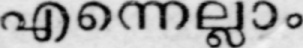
എന്നെല്ലാം
